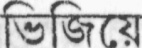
ভিজিয়ে
